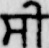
ਸੀ
